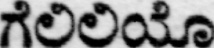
ಗೆಲಿಲಿಯೊ
